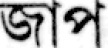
জাপ
